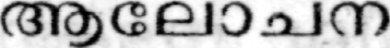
ആലോചന
